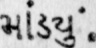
માંડ્યું.
